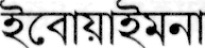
ইবোয়াইমনা
